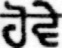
ਹੋਵੇ
